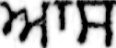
ਆਸ
